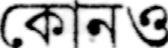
কোনও
